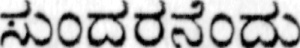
ಸುಂದರನೆಂದು
